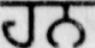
ਹਨ
